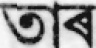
তাৰ
